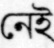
নেই
